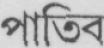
পাতিব
